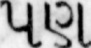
પણ
